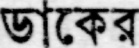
ডাকের
